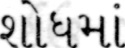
શોધમાં
